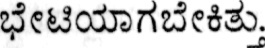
ಭೇಟಿಯಾಗಬೇಕಿತ್ತು.
